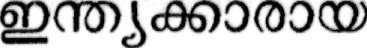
ഇന്ത്യക്കാരായ
